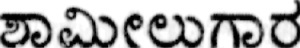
ಶಾಮೀಲುಗಾರ
